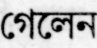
গেলেন
